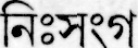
নিঃসংগ
